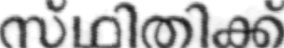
സ്ഥിതിക്ക്
